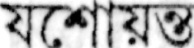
যশোয়ন্ত
